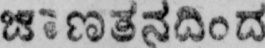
ಜಾಣತನದಿಂದ
